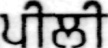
ਪੀਲੀ
